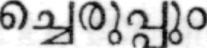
ച്ചെരുപ്പും
